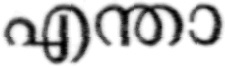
എന്താ
